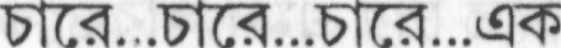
চারে...চারে...চারে...এক
